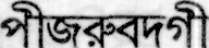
পীজরুবদগী
